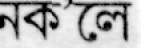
নক'লে
